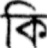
কি
